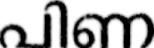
പിണ
